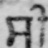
ਸੀ
